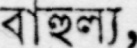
বাহুল্য,
